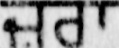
ਜ਼ਰਾ
